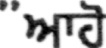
''ਆਹੋ
